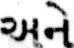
અને
